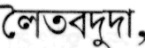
লৈতবদুদা,
